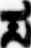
ಸ
